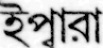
ইপ্বারা
